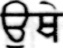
ਉਥੇ
